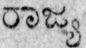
ರಾಜ್ಯ
